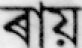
ৰায়
